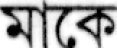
মাকে
